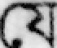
যে
